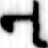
ન
